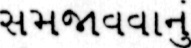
સમજાવવાનું
